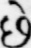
છે
